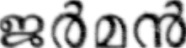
ജര്‍മന്‍
